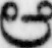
ಆ
